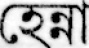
হেন্না
